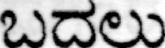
ಬದಲು
